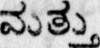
ಮತ್ತು
